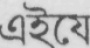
এইযে
